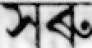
সৰু
